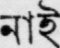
নাই
